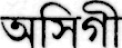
অসিগী
